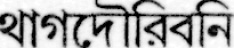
থাগদৌরিবনি
